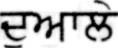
ਦੁਆਲੇ
